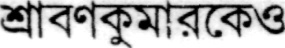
শ্রাবণকুমারকেও
